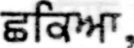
ਛਕਿਆ,
